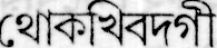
থোকখিবদগী
